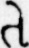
તે
